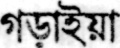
গড়াইয়া
